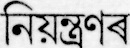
নিয়ন্ত্রণৰ
